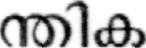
ന്തിക
